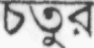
চতুর
